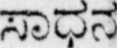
ಸಾಧನ
